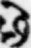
છે
